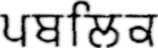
ਪਬਲਿਕ
